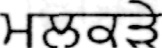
ਮਲਕੜੇ
